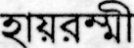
হায়রম্মী
